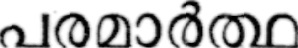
പരമാര്‍ത്ഥ
